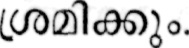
ശ്രമിക്കും.
